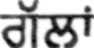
ਗੱਲਾਂ
